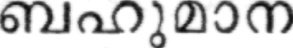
ബഹുമാന
